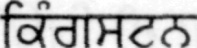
ਕਿੰਗਸਟਨ
